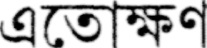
এতোক্ষণ
